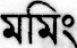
মমিং
